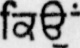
ਕਿਉਂ
